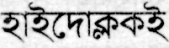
হাইদোক্লকই
